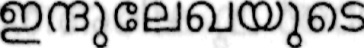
ഇന്ദുലേഖയുടെ
